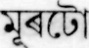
মূৰটো
